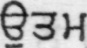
ਉਤਮ
